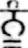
ਨੂੰ
